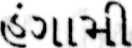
હંગામી
